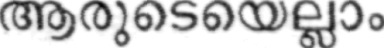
ആരുടെയെല്ലാം
